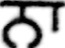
ਨਾ
